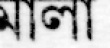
মালা
